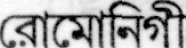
রোমোনিগী
